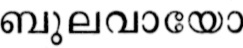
ബുലവായോ
